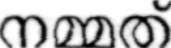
നമ്മത്
